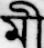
মী
